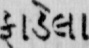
ફાડેલા
